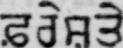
ਫ਼ਰੇਸ਼ਤੇ
